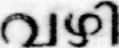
വഴി
